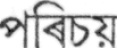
পৰিচয়
